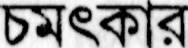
চমৎকার
